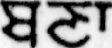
ਬਣਾ
